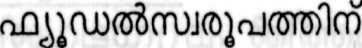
ഫ്യൂഡല്‍സ്വരൂപത്തിന്
